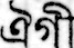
ঐগা
